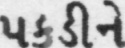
પકડીને
